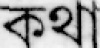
কথা
